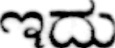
ಇದು
